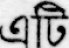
এটি
